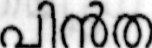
പിന്‍ത
